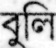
বুলি
